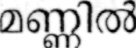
മണ്ണില്‍
